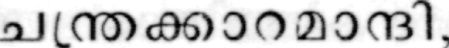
ചന്ത്രക്കാറമാന്ദി,
